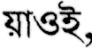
য়াওই,
